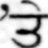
'ਤੇ
